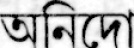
অনিদো
